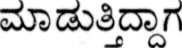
ಮಾಡುತ್ತಿದ್ದಾಗ
